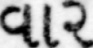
વાર
